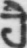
ਹੈ
